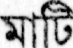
মাটি
